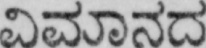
ವಿಮಾನದ
